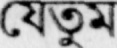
যেতুম
